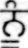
ਨੂੰ
